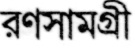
রণসামগ্রী
